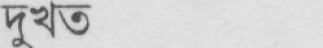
দুখত
